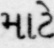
માટે
